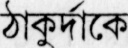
ঠাকুর্দাকে
